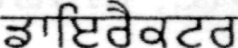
ਡਾਇਰੈਕਟਰ
